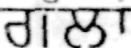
ਗੱਲਾਂ
